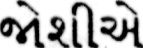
જોશીએ
